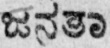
ಜನತಾ
